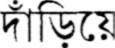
দাঁড়িয়ে
